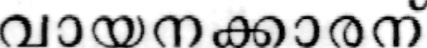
വായനക്കാരന്
